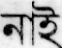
নাই
